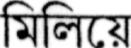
মিলিয়ে
